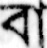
বা
